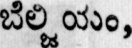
ಬೆಲ್ಜಿಯಂ,
